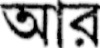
আর
